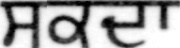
ਸਕਦਾ
